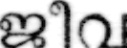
ജീവ
